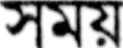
সময়
